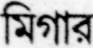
মিগার
